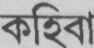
কহিবা
